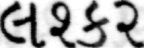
લશ્કર
